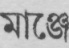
মাঞ্জে
